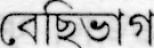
বেছিভাগ
